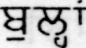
ਬੁਲ੍ਹਾਂ
